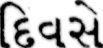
દિવસે
